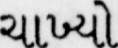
ચાખ્યો
